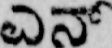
ಎನ್
